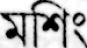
মশিং
